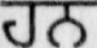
ਹਨ
